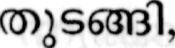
തുടങ്ങി,
